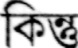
কিন্তু
